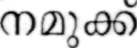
നമുക്ക്
